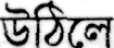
উঠিলে
